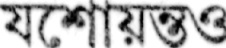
যশোয়ন্তও
